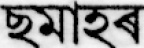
ছমাহৰ
